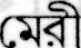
মেরী
